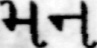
મન
